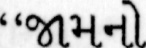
"જામનો
